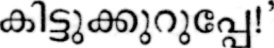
കിട്ടുക്കുറുപ്പേ!’
